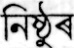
নিষ্ঠুৰ
